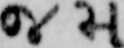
જમ
